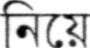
নিয়ে
